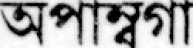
অপাম্বগা
